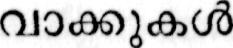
വാക്കുകള്‍
